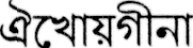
ঐখোয়গীনা
